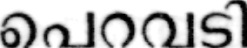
പെറവടി
